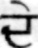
ਦੇ
